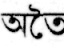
অতৈ
